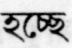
হচ্ছে
